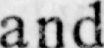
and
